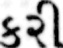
કરી
